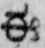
ಈ
